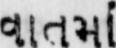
વાતમાં
